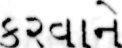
કરવાને
